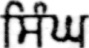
ਸਿੰਘ
